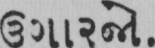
ઉગારજો.
